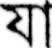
যা
